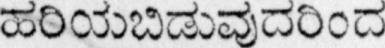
ಹರಿಯಬಿಡುವುದರಿಂದ
